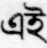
এই
